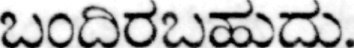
ಬಂದಿರಬಹುದು.
